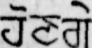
ਹੋਣਗੇ
